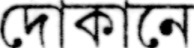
দোকানে
